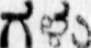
ಗಳು
